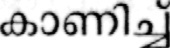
കാണിച്ച്
